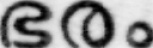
ഭരം
